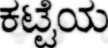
ಕಟ್ಟೆಯ
